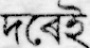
দৰেই
